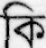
কি
